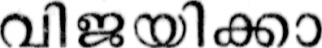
വിജയിക്കാ
